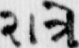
રાત્રે
